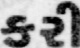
કરી
